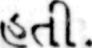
હતી.
